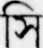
সি
